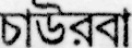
চাউরবা
